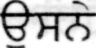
ਉਸਨੇ
